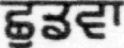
ਛੁਡਵਾ
